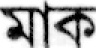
মাক
